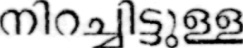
നിറച്ചിട്ടുള്ള
